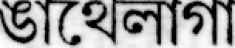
ঙাথেলাগা
